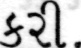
કરી.
